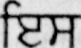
ਇਸ
